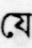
যে
